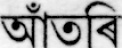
আঁতৰি
